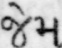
જેમ
